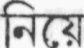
নিয়ে
